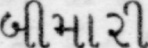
બીમારી
